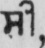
ਸੀ,
